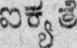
ಐಕ್ಯತೆ
